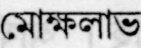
মোক্ষলাভ
